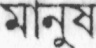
মানুষ
